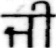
ਜੀ
